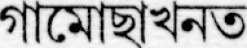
গামোছাখনত
